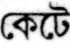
কেটে
